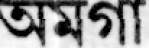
অমগা
